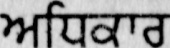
ਅਧਿਕਾਰ
